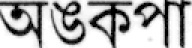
অঙকপা
